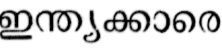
ഇന്ത്യക്കാരെ
